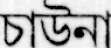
চাউনা
